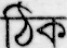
ঠিক
